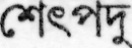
শেৎপদু
